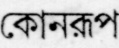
কোনরূপ
